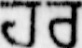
ਹਰ
